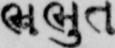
ભભુત
